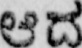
ಆದ
